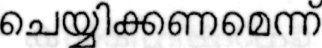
ചെയ്യിക്കണമെന്ന്
